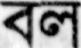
বল
